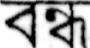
বন্ধ
